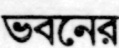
ভবনের
